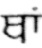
ਥਾਂ
